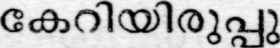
കേറിയിരുപ്പു
